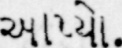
આપ્યો.
